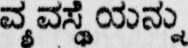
ವ್ಯವಸ್ಥೆಯನ್ನು
